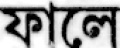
ফালে
